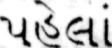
પહેલાં
